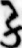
કે
